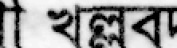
কয়ারক
